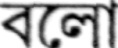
বলো
